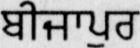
ਬੀਜਾਪੁਰ
